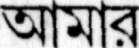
আমার
